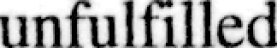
unfulfilled
